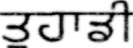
ਤੁਹਾਡੀ
